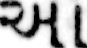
આ
